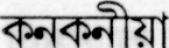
কনকনীয়া
